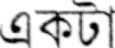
একটা
